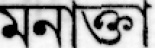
মনাক্তা
